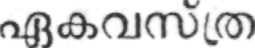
ഏകവസ്ത്ര
